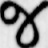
જ
